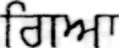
ਗਿਆ
